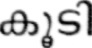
കൂടി
